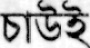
চাউই
